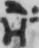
ਮੈਂ
